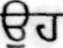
ਉਹ
